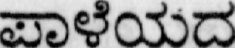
ಪಾಳೆಯದ
